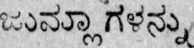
ಜುಮ್ಲಾಗಳನ್ನು
